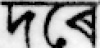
দৰে
